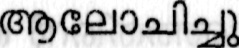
ആലോചിച്ചു
